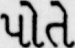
પોતે
